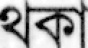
থকা
